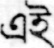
এই
